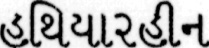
હથિયારહીન
